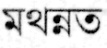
মথন্নত
